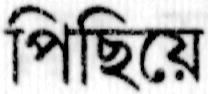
পিছিয়ে
